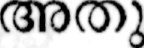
അതു
